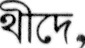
থীদে,
